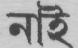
নাই
